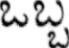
ಒಬ್ಬ
